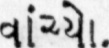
વાંચ્યો.
